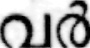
വര്‍
